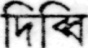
দিব্বি
